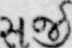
સર્જી
